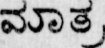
ಮಾತ್ರ
